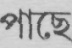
পাছে
